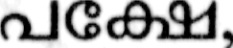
പക്ഷേ,
